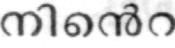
നിന്റെ
